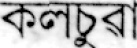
কলচুৱা
